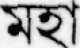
মহা
